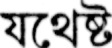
যথেষ্ট
